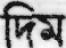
দিম
